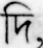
দি,
